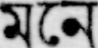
মনে
